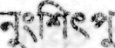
নুংশিৎপু
